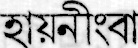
হায়নীংবা
